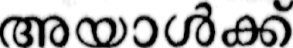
അയാള്‍ക്ക്
